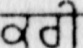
ਕਰੀ
